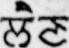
ਲੈਣ
